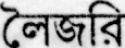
লৈজরি
